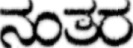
ನಂತರ
